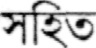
সহিত
